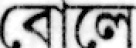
বোলে
